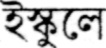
ইস্কুলে
